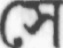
সে
